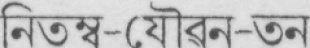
নিতম্ব-যৌৱন-তন
